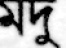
মদু
